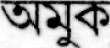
অমুক
